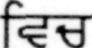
ਵਿਚ
